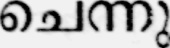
ചെന്നു
